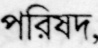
পরিষদ,
